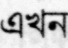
এখন
